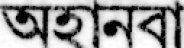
অহানবা
